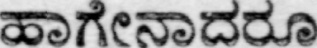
ಹಾಗೇನಾದರೂ
